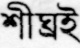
শীঘ্রই
